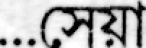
...সেয়া
